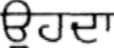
ਉਹਦਾ
